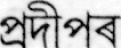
প্ৰদীপৰ
